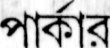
পার্কার
